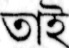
তাই
